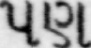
પણ
